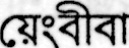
য়েংবীবা
